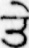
ਤੇ
